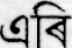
এৰি
